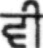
ਵੀ
